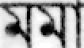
মমা
